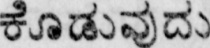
ಕೊಡುವುದು
